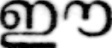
ഈ
